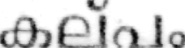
കല്പം
